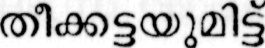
തീക്കട്ടയുമിട്ട്
